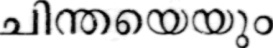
ചിന്തയെയും
